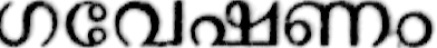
ഗവേഷണം
